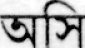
অসি
